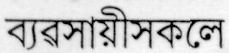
ব্যৱসায়ীসকলে
